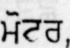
ਮੋਟਰ,
